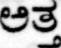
ಅತ್ತ
